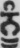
ਨੂੰ
